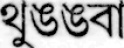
থুঙঙবা
